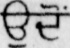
ਉਦੋਂ
